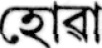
হোৱা
